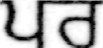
ਪਰ
